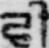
ਵੀ
